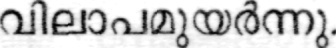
വിലാപമുയര്‍ന്നു.
